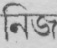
নিজ
